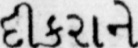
દીકરાને
